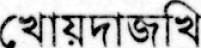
খোয়দাজখি
